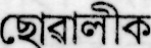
ছোৱালীক
